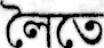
লৈতে
